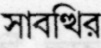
সাবত্থির
